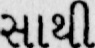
સાથી
